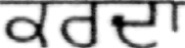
ਕਰਦਾ
